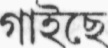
গাইছে
